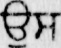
ਉਸ
